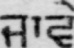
ਜਾਵੇ
